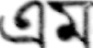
এম
